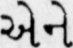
એને
